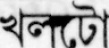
খলটো
